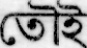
তৌই
